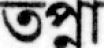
তপ্না
